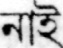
নাই
